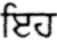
ਇਹ
